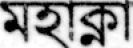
মহাক্না
